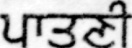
ਪਾਤਣੀ
